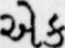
એક
